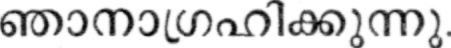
ഞാനാഗ്രഹിക്കുന്നു.
